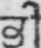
ਭੀ
